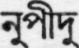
নুপীদু
